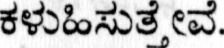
ಕಳುಹಿಸುತ್ತೇವೆ.
